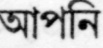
আপনি
